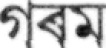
গৰম
